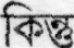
কিন্তু
